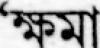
'ক্ষমা
